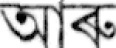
আৰু
